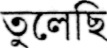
তুলেছি
